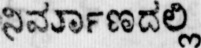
ನಿರ್ಮಾಣದಲ್ಲಿ
